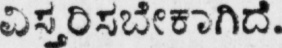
ವಿಸ್ತರಿಸಬೇಕಾಗಿದೆ.
